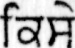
ਕਿਸੇ
